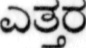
ಎತ್ತರ
